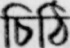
চিঠি
